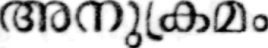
അനുക്രമം
